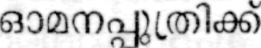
ഓമനപ്പുത്രിക്ക്
